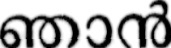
ഞാന്‍
